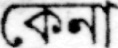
কেনা
